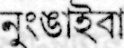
নুংঙাইবা
